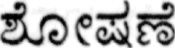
ಶೋಷಣೆ
